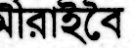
মীরাইবৈ
